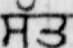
ਸੱਤ
